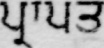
ਪ੍ਰਾਪਤ
